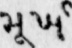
મૂર્ખ
